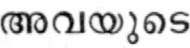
അവയുടെ
